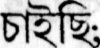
চাইছি,
